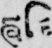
હ્યદિ
